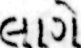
લાગે
